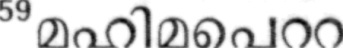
59മഹിമപെററ
